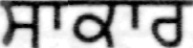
ਸਾਕਾਰ
